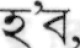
হ'ব,
